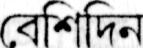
বেশিদিন
